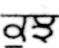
ਕੁਝ
